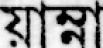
য়াম্না
